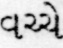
વચ્ચે
